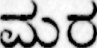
ಮರ
